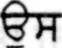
ਉਸ
